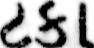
ટકા
